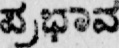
ಪ್ರಭಾವ
